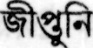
জীপ্তুনি
